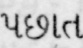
પછાત
